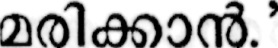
മരിക്കാന്‍.’
